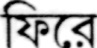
ফিরে
